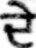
ਦੇ
